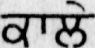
ਕਾਲੇ
